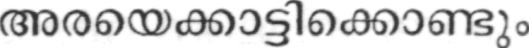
അരയെക്കാട്ടിക്കൊണ്ടും
